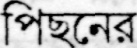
পিছনের
